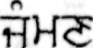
ਜੰਮਣ
